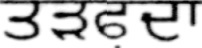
ਤੜਫ਼ਦਾ
